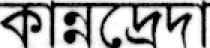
কান্নদ্রেদা
